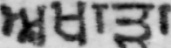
ਅਖਾੜਾ
